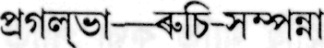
প্রগলভা-ৰুচি-সম্পন্না
